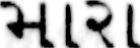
મારા
